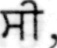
ਸੀ,
